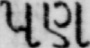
પણ
